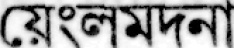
য়েংলমদনা
